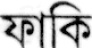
ফাকি
